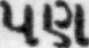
પણ
